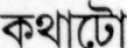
কথাটো
